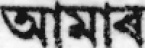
আমাৰ
